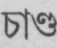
চাণ্ড
